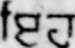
ਇਹ
